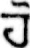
ਹੋ
